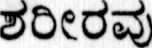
ಶರೀರವು
